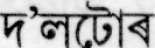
দ'লটোৰ
